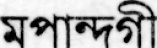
মপান্দগী
